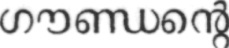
ഗൗണ്ഡന്റെ
